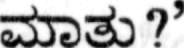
ಮಾತು?’
